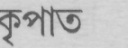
কৃপাত
